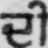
ਦੀ
